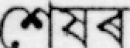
শেষৰ
